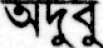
অদুবু
